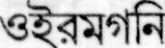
ওইরমগনি
